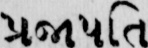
પ્રજાપતિ
